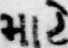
માટે
